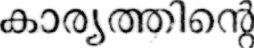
കാര്യത്തിന്റെ
